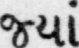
જ્યાં
